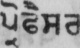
ਪ੍ਰੋਫੈਸਰ
